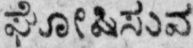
ಘೋಷಿಸುವ
